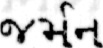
જર્મન
